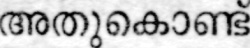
അതുകൊണ്ട്
